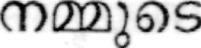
നമ്മുടെ
